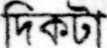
দিকটা
